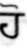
ਹੋ
